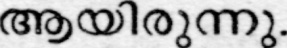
ആയിരുന്നു.
